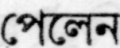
পেলেন
